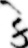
કે
